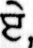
ਏ,
